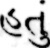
હતું
